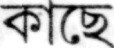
কাছে
